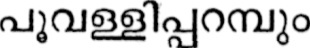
പൂവള്ളിപ്പറമ്പും
